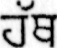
ਹੱਥ
